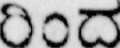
ರಿಂದ
